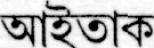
আইতাক
